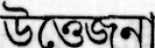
উত্তেজনা
